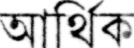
আর্থিক
